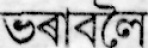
ভৰাবলৈ
